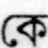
কে
